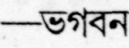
–ভগবন
